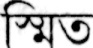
স্মিত
